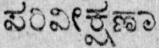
ಪರಿವೀಕ್ಷಣಾ
